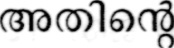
അതിന്റെ
